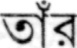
তাঁর
